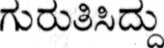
ಗುರುತಿಸಿದ್ದು
